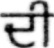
ਦੀ
